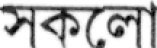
সকলো
